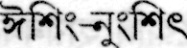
ঈশিং-নুংশিৎ
